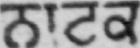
ਨਾਟਕ
